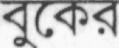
বুকের
